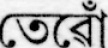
তেৱোঁ
